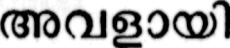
അവളായി
